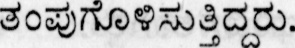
ತಂಪುಗೊಳಿಸುತ್ತಿದ್ದರು.
